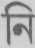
নি
